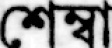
শেম্বা
